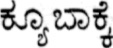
ಕ್ಯೂಬಾಕ್ಕೆ
